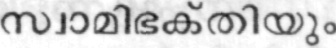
സ്വാമിഭക്തിയും
